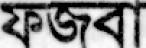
ফজবা
